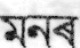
মনৰ
